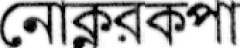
নোক্নরকপা
